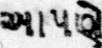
આપણે
